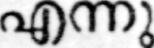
എന്നു
